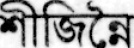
শীজিন্নৈ
